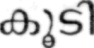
കൂടി
